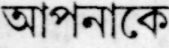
আপনাকে
